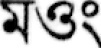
মওং
